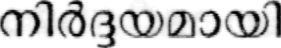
നിര്‍ദ്ദയമായി
